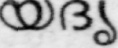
യദൃ
